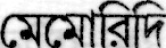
মেমোরিদি
